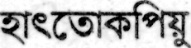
হাৎতোকপিয়ু
